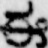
ಈ
